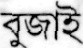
বুজাই
